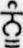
ਨੂੰ
